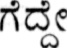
ಗೆದ್ದೇ
